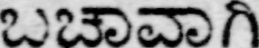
ಬಚಾವಾಗಿ
